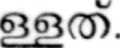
ള്ളത്.
